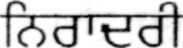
ਨਿਰਾਦਰੀ
